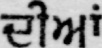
ਦੀਆਂ
